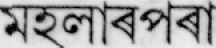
মহলাৰপৰা
